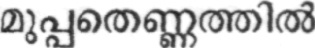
മുപ്പതെണ്ണത്തില്‍
